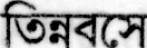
তিন্নবসে
